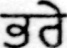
ਭਰੇ
